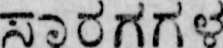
ಸಾರಗಗಳ
